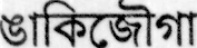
ঙাকিজৌগা
